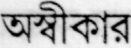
অস্বীকার
